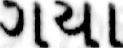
ગયા
